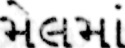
મેલમાં
